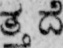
ತ್ತದೆ
